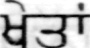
ਖ਼ੇਤਾਂ
